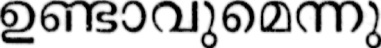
ഉണ്ടാവുമെന്നു
